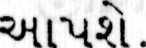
આપશે.
